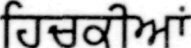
ਹਿਚਕੀਆਂ
